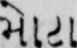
મોટા
